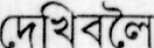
দেখিবলৈ
